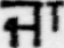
ਜਾ
